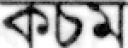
কচম
